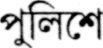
পুলিশে
